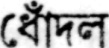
ধোঁদল
